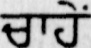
ਚਾਹੇਂ
